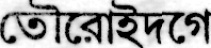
তৌরোইদগে
